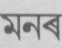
মনৰ
